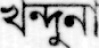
খন্দুনা
